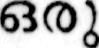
ഒരു
